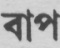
বাপ
